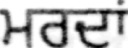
ਮਰਦਾਂ
